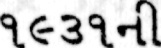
૧૯૩૧ની
